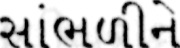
સાંભળીને
